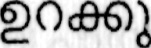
ഉറക്കു
